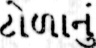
ટોળાનું
